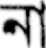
না
